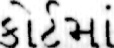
કોર્ટમાં
